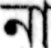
না
